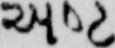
અષ્ટ
